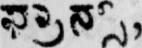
ಫ್ರಾನ್ಸ್,
